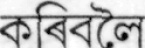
কৰিবলৈ
